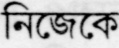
নিজেকে
